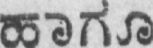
ಹಾಗೂ
